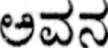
ಅವನ
